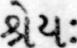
શ્રેય:
